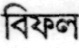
বিফল
